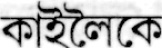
কাইলৈকে
